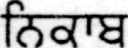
ਨਿਕਾਬ
